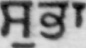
ਸੁਭਾ
